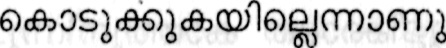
കൊടുക്കുകയില്ലെന്നാണു
